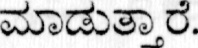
ಮಾಡುತ್ತಾರೆ.
